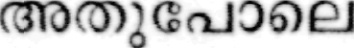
അതുപോലെ
